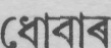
ধোবাৰ
